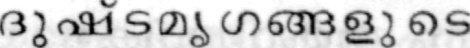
ദുഷ്ടമൃഗങ്ങളുടെ
